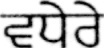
ਵਧੇਰੇ
